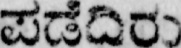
ಪಡೆದಿರು
